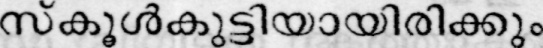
സ്കൂള്‍കുട്ടിയായിരിക്കും
